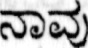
ನಾವು
